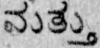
ಮತ್ತು
